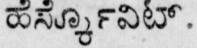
ಹೆರ್ಸ್ಕೊವಿಟ್.
